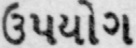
ઉપયોગ
